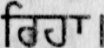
ਰਿਹਾ।
